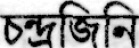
চন্দ্রজিনি
